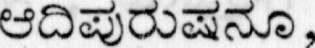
ಆದಿಪುರುಷನೂ,
